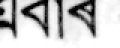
এবাৰ
